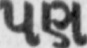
પણ
